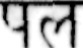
पल
